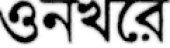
ওনখরে
